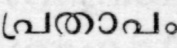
പ്രതാപം
